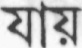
যায়
